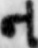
ન
